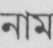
নাম
